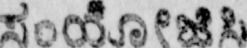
ಸಂಯೋಜಿಸಿ
